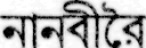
নানবীরৈ
